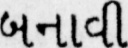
બનાવી
